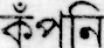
কঁপনি
